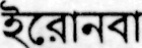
ইরোনবা
